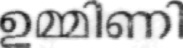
ഉമ്മിണി
